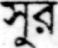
সুর
